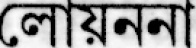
লোয়ননা
